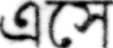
এসে
